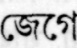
জেগে
